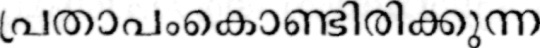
പ്രതാപംകൊണ്ടിരിക്കുന്ന
